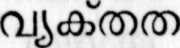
വ്യക്തത
